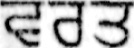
ਵਰਤ
